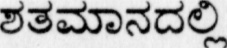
ಶತಮಾನದಲ್ಲಿ
